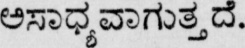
ಅಸಾಧ್ಯವಾಗುತ್ತದೆ.
